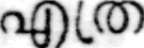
എത്ര
